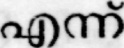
എന്ന്
